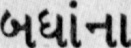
બધાંના
